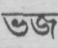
ভজ
